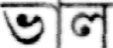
ভাল
